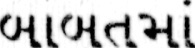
બાબતમાં
